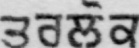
ਤਰਲੋਕ
